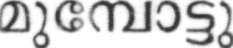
മുമ്പോട്ടു
